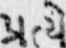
પ્રત્યે
